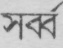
সৰ্ব্ব
